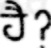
ਹੈ?
